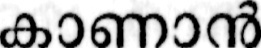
കാണാന്‍
